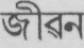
জীৱন
